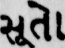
સૂતો
